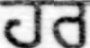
ਹਰ
